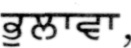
ਭੁਲਾਵਾ,
